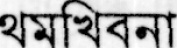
থমখিবনা
